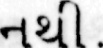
નથી.
